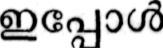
ഇപ്പോള്‍
